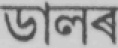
ডালৰ
